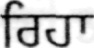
ਰਿਹਾ
